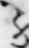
કે
